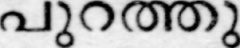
പുറത്തു
